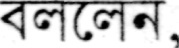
বললেন,
